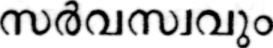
സര്‍വസ്വവും
